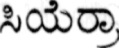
ಸಿಯೆರ್ರಾ
